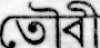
তৌবী
